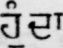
ਹੁੰਦਾ
